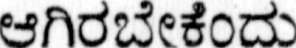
ಆಗಿರಬೇಕೆಂದು
